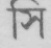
সি
